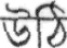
উঠি
